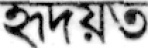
হৃদয়ত
